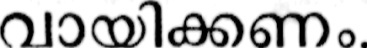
വായിക്കണം.
